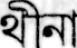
থীনা
